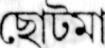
ছোটমা
